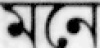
মনে
